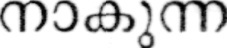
നാകുന്ന
